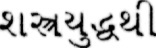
શસ્ત્રયુદ્ધથી
